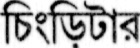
চিংড়িটার
